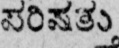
ಪರಿಷತ್ತು
